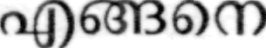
എങ്ങനെ
